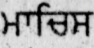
ਮਾਚਿਸ
